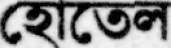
হোতেল
